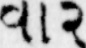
વાર
